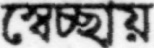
স্বেচ্ছায়
